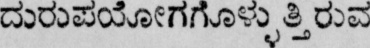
ದುರುಪಯೋಗಗೊಳ್ಳುತ್ತಿರುವ
